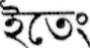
ইতেং
